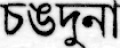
চঙদুনা
